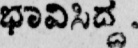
ಭಾವಿಸಿದ್ದ.
